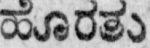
ಹೊರತು
